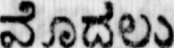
ಮೊದಲು
